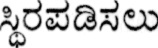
ಸ್ಥಿರಪಡಿಸಲು
